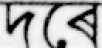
দৰে
